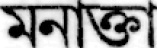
মনাক্তা
